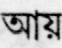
আয়
